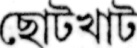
ছোটখাট
